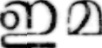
ഇമ
